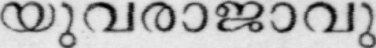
യുവരാജാവു
